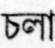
চলা
